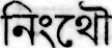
নিংথৌ
